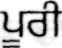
ਪੂਰੀ
